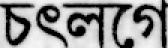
চৎলগে
